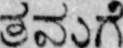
ತಮಗೆ
